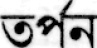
তর্পন
